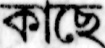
কাছে
